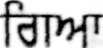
ਗਿਆ
